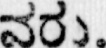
ವರು.
